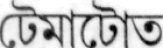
টেমাটোত
